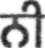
ਨੀ
